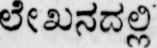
ಲೇಖನದಲ್ಲಿ
